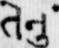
તેનું
